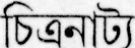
চিত্রনাট্য
